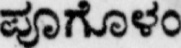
ಪೂಗೊಳಂ
